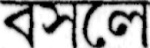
বসলে
